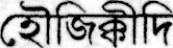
হৌজিক্কীদি
